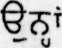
ਉਨ੍ਹਾਂ
